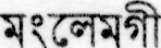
মংলেমগী
